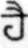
ਹੈ
